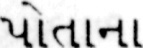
પોતાના
